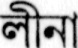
লীনা
